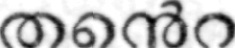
തന്റെ
